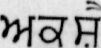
ਅਕਸ਼ੈ
